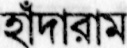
হাঁদারাম
